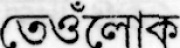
তেওঁলোক
